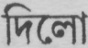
দিলো
